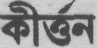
কীৰ্ত্তন
